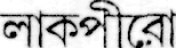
লাকপীরো
